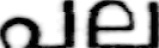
പല
